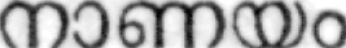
നാണയം
